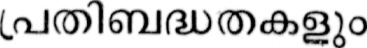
പ്രതിബദ്ധതകളും
